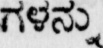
ಗಳನ್ನು
